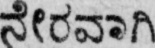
ನೇರವಾಗಿ
